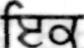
ਇਕ
